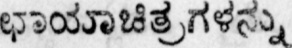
ಛಾಯಾಚಿತ್ರಗಳನ್ನು
